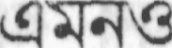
এমনও
